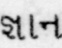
જ્ઞાન
